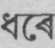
ধৰে
